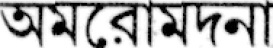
অমরোমদনা
